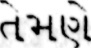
તેમણે
